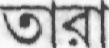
তারা
